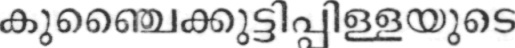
കുഞ്ചൈക്കുട്ടിപ്പിള്ളയുടെ
